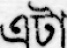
এটা
